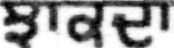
ਝਾਕਦਾ
